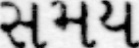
સમય
